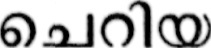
ചെറിയ
